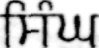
ਸਿੰਘ
